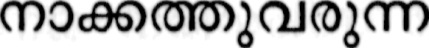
നാക്കത്തുവരുന്ന
